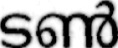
ടണ്‍
